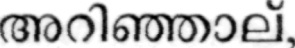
അറിഞ്ഞാല്,
